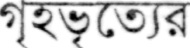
গৃহভৃত্যের
